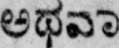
ಅಥವಾ
